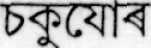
চকুযোৰ
